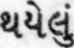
થયેલું
